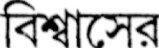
বিশ্বাসের
